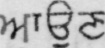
ਆਉਣ
